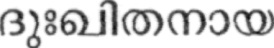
ദുഃഖിതനായ
